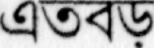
এতবড়
